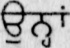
ਉਨ੍ਹਾਂ
